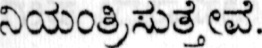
ನಿಯಂತ್ರಿಸುತ್ತೇವೆ.
